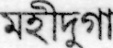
মহীদুগা
